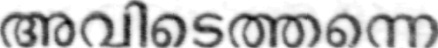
അവിടെത്തന്നെ
